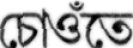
চোওঁতে
